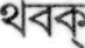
থবক্
